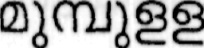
മുമ്പുള്ള
